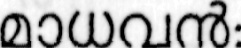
മാധവന്‍:
